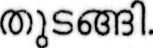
തുടങ്ങി.
